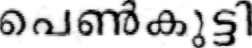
പെണ്‍കുട്ടി
